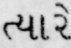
ત્યારે
